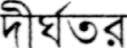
দীর্ঘতর
